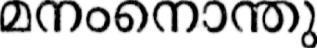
മനംനൊന്തു
